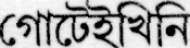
গোটেইখিনি
